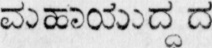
ಮಹಾಯುದ್ದದ
